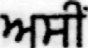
ਅਸੀਂ
